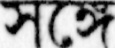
সঙ্গে
